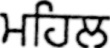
ਮਹਿਲ
